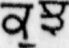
ਕੁਝ
